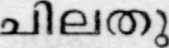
ചിലതു
